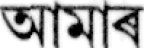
আমাৰ
